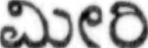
ಮೀರಿ
